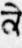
ਕੇ
